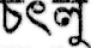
চৎলু
